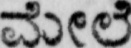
ಮೇಲೆ
